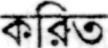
করিত
